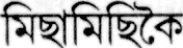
মিছামিছিকৈ
